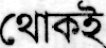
থোকই
